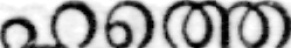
ഹത്തെ
